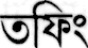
তফিং
